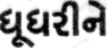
ધૂધરીને
